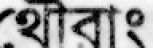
থৌরাং
